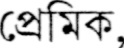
প্রেমিক,
